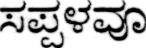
ಸಪ್ಪಳವೂ
